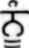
ਨੂੰ
